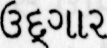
ઉદ્ગાર
